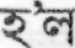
হ'ল
